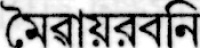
মৈৱায়রবনি
